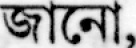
জানো,
